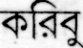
করিবু
